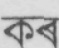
কৰ
